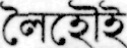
লৈহৌই
